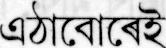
এঠাবোৰেই
